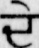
ਦੇ
